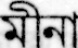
মীনা
